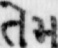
તેમ
